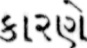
કારણે
